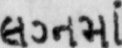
લગ્નમાં
